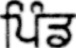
ਪਿੰਡ
